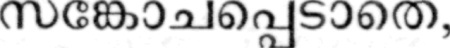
സങ്കോചപ്പെടാതെ,
